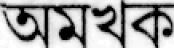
অমখক
